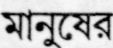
মানুষের
